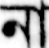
না
